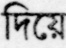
দিয়ে
